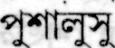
পুশালুসু
